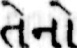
તેનો
